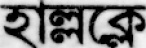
হাল্লক্লে
